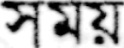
সময়
